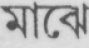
মাঝে
